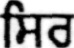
ਸਿਰ
